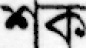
শক
